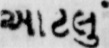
આટલું
